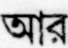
আর
